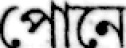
পোনে
